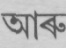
আৰু
